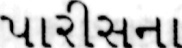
પારીસના
